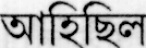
আহিছিল
